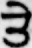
ਤੇ
